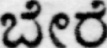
ಬೇರೆ
